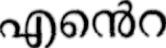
എന്റെ
